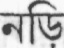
নড়ি
